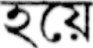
হয়ে
